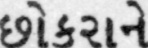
છોકરાને
